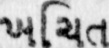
ખચિત
